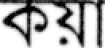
কয়া
